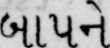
બાપને
